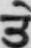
ਤੇ
